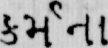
કર્મના
